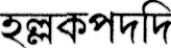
হল্লকপদদি
